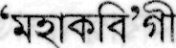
‘মহাকবি’গী
